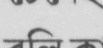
বিচাৰি
